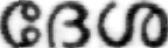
ദേശ
